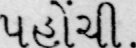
પહોંચી.
